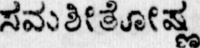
ಸಮಶೀತೋಷ್ಣ
